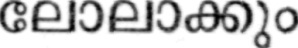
ലോലാക്കും
